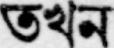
তখন
